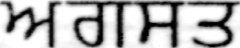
ਅਗਸਤ
